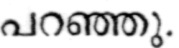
പറഞ്ഞു.
